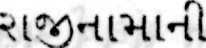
રાજીનામાની
